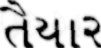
તૈયાર
